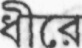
ধীরে
